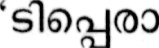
‘ടിപ്പെരാ
